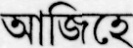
আজিহে
